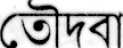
তৌদবা
